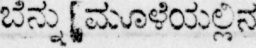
ಬೆನ್ನು[ಮೂಳೆಯಲ್ಲಿನ
